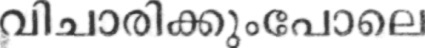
വിചാരിക്കുംപോലെ
